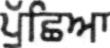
ਪੁੱਛਿਆ
